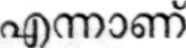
എന്നാണ്
